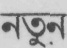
নতুন
